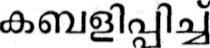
കബളിപ്പിച്ച്
